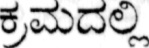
ಕ್ರಮದಲ್ಲಿ
